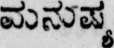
ಮನುಷ್ಯ
